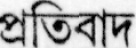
প্রতিবাদ
